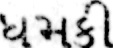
ધમકી
